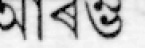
আৰম্ভ
